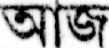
আজ
